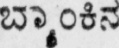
ಬ್ಯಾಂಕಿನ
